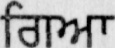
ਗਿਆ
